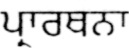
ਪ੍ਰਾਰਥਨਾ
